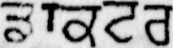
ਡਾਕਟਰ
